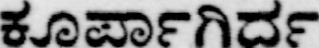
ಕೂರ್ಪಾಗಿರ್ದ
